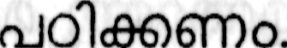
പഠിക്കണം.
